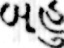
બહુ
